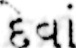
દેવાં
